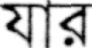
যার
